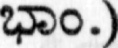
ಭಾಂ.)
